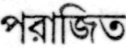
পরাজিত
